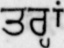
ਤਰ੍ਹਾਂ
